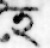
হৈ
